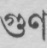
গুণ
